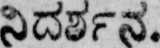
ನಿದರ್ಶನ.
